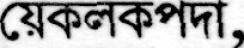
য়েকলকপদা,
